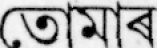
তোমাৰ
